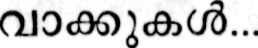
വാക്കുകള്‍...
